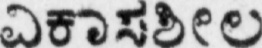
ವಿಕಾಸಶೀಲ
